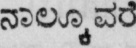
ನಾಲ್ಕೂವರೆ
